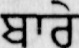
ਬਾਰੇ
